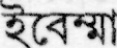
ইবেম্মা
